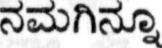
ನಮಗಿನ್ನೂ
